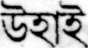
উহাই
